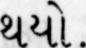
થયો.
